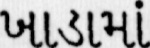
ખાડામાં
